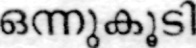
ഒന്നുകൂടി
